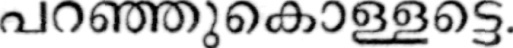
പറഞ്ഞുകൊള്ളട്ടെ.
